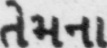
તેમના
